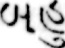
બહુ
